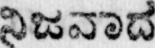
ನಿಜವಾದ
